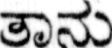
ತಾನು
